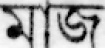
মাজ
